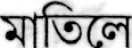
মাতিলে
